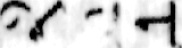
જન
